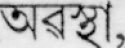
অৱস্থা,
